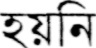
হয়নি
